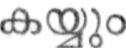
കയ്യും
